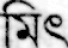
মিৎ
